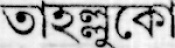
তাহল্লুকো
